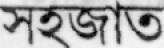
সহজাত
